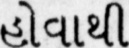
હોવાથી
